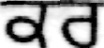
ਕਰ
